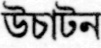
উচাটন
